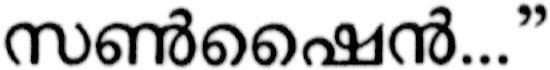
സണ്‍ഷൈന്‍...”
